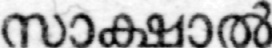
സാക്ഷാല്‍
